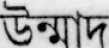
উন্মাদ
